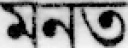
মনত
